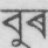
বুৰ
